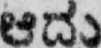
ಆದು
